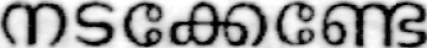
നടക്കേണ്ടേ
